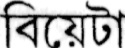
বিয়েটা
